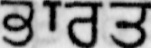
ਭਾਰਤ
